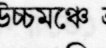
উচ্চমঞ্চে
